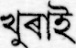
খুৰাই
